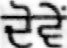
ਦੋਵੇਂ
